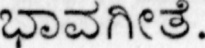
ಭಾವಗೀತೆ.
